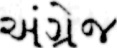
અંગ્રેજ
